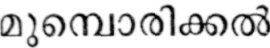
മുമ്പൊരിക്കല്‍
